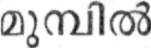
മുമ്പില്‍
